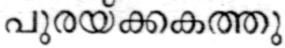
പുരയ്ക്കകത്തു
